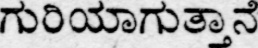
ಗುರಿಯಾಗುತ್ತಾನೆ
